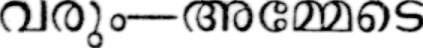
വരും-അമ്മേടെ
